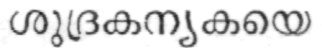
ശൂദ്രകന്യകയെ
